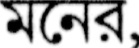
মনের,
